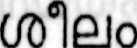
ശീലം
